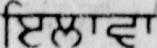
ਇਲਾਵਾ
